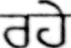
ਰਹੇ
